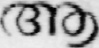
ആ
